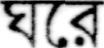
ঘরে
